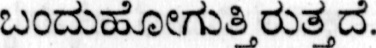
ಬಂದುಹೋಗುತ್ತಿರುತ್ತದೆ.
